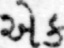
એક
